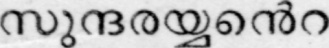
സുന്ദരയ്യന്റെ
